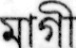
মাগী
